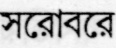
সরোবরে
